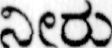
ನೀರು
